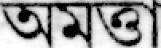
অমত্তা
